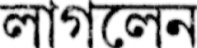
লাগলেন
